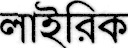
লাইরিক
